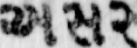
અસર
